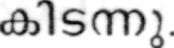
കിടന്നു.
